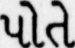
પોતે
